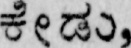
ಕೇಡು,
